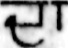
ਦਾ
